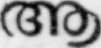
ആ
